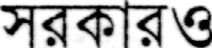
সরকারও
